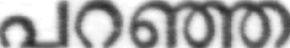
പറഞ്ഞ
